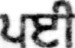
ਪਈ
